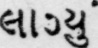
લાગ્યું
